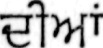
ਦੀਆਂ
